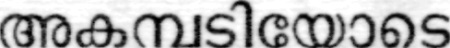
അകമ്പടിയോടെ
